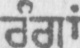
ਰੰਗਾਂ
